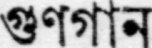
গুণগান
